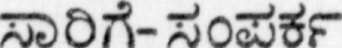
ಸಾರಿಗೆ-ಸಂಪರ್ಕ
